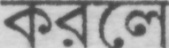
করলে
